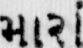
મારાં
